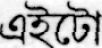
এইটো
